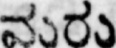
ಮರು
